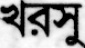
খরসু
